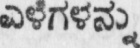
ಎಳೆಗಳನ್ನು
